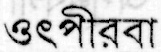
ওৎপীরবা
